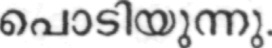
പൊടിയുന്നു.
